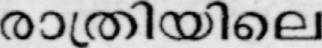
രാത്രിയിലെ
